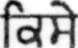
ਕਿਸੇ
